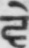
ਵੇ
